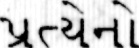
પ્રત્યેનો
